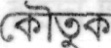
কৌতুক
